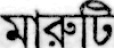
মারুটি
